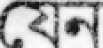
যেন
